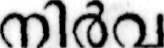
നിര്‍വ
